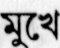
মুখে
